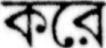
করে
